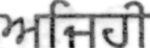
ਅਜਿਹੀ
